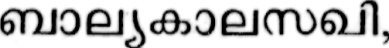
ബാല്യകാലസഖി,
